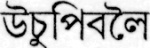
উচুপিবলৈ
